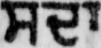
ਸਦਾ
